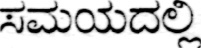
ಸಮಯದಲ್ಲಿ
